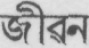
জীৱন
